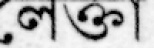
লেক্তা
